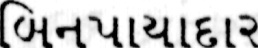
બિનપાયાદાર
